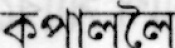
কপাললৈ
